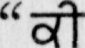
''ਕੀ
